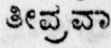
ತೀವ್ರವಾ
